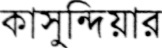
কাসুন্দিয়ার
